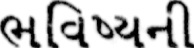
ભવિષ્યની
